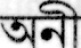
অনী
